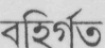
বহিৰ্গত
